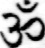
ૐ
